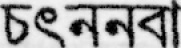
চৎননবা
